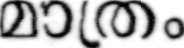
മാത്രം
